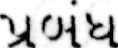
પ્રબંધ
